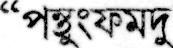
“পন্থুংফমদু
